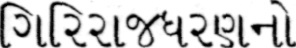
ગિરિરાજધરણનો
